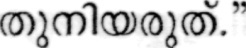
തുനിയരുത്.”
